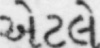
એટલે
